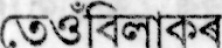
তেওঁবিলাকৰ
